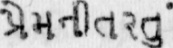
પ્રેમનીતરતું
